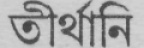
তীৰ্থানি
